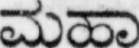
ಮಹಾ
